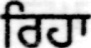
ਰਿਹਾ
